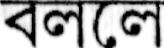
বললে
